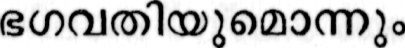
ഭഗവതിയുമൊന്നും
